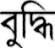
বুদ্ধি
